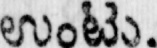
ಉಂಟು.
